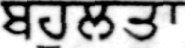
ਬਹੁਲਤਾ
